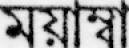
ময়াম্বা
